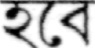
হবে
